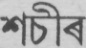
শচীৰ
